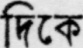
দিকে
